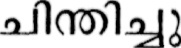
ചിന്തിച്ചു
